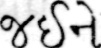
જઈને
